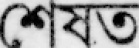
শেষত
